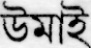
উমাই
